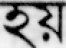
হয়
